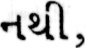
નથી,
